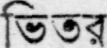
ভিতর
